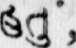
હતું,
